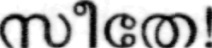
സീതേ!
